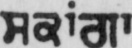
ਸਕਾਂਗਾ
